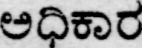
ಅಧಿಕಾರ
